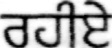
ਰਹੀਏ
